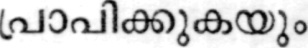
പ്രാപിക്കുകയും
